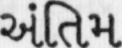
અંતિમ
